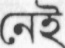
নেই
